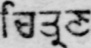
ਚਿਤ੍ਰਣ
